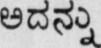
ಅದನ್ನು
